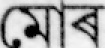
মোৰ
